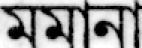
মমানা
